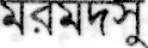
মরমদসু
